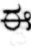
ಈ
